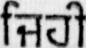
ਜਿਹੀ
